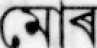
মোৰ
